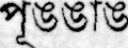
পূঙঙাঙ
